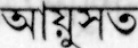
আয়ুসত
